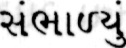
સંભાળ્યું
